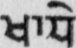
ਖਾਧੇ
